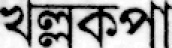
খল্লকপা
